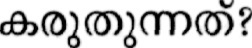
കരുതുന്നത്?
